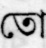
তো
